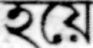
হয়ে
